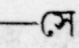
–সে
